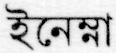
ইনেম্না
